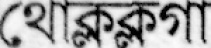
থোক্লক্লগা
